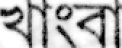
খাংবা
